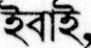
ইবাই,
